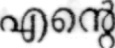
എന്റെ
